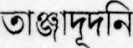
তাঞ্জাদূদনি
